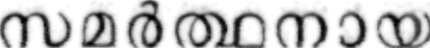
സമര്‍ത്ഥനായ
